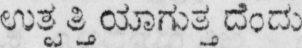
ಉತ್ಪತ್ತಿಯಾಗುತ್ತದೆಂದು
